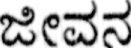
ಜೀವನ
